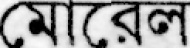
মোরেল
